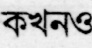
কখনও
